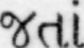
જતાં
